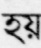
হয়
